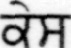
ਕੇਸ
